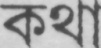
কথা
